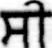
ਸੀ
